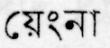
য়েংনা
